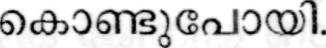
കൊണ്ടുപോയി.
